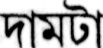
দামটা
